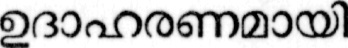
ഉദാഹരണമായി
